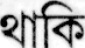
থাকি
